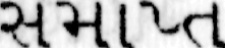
સમાપ્ત
